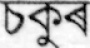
চকুৰ
